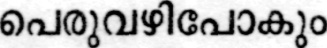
പെരുവഴിപോകും
